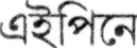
এইপিনে
